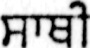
ਸਾਥੀ
